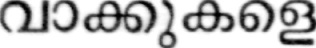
വാക്കുകളെ
